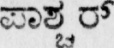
ಪಾಶ್ಚರ್
